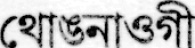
থোঙনাওগী
